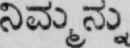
ನಿಮ್ಮನ್ನು
